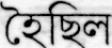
হৈছিল
